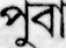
পুবা
